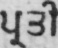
ਪ੍ਰਤੀ
